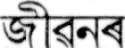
জীৱনৰ
